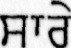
ਸਾਰੇ
